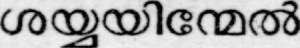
ശയ്യയിന്മേല്‍
